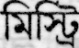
মিস্ট্রি
